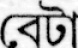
বেটা
